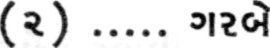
(૨).........ગરબે
